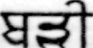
ਬੜੀ
